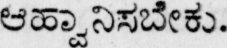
ಆಹ್ವಾನಿಸಬೇಕು.
